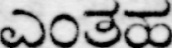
ಎಂತಹ
